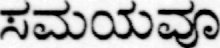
ಸಮಯವೂ
